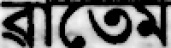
ৱাতেম
